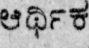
ಆರ್ಥಿಕ
